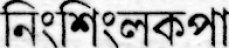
নিংশিংলকপা
